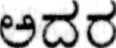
ಅದರ
